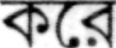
করে
